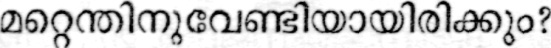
മറ്റെന്തിനുവേണ്ടിയായിരിക്കും?
